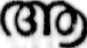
ആ
